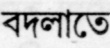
বদলাতে
